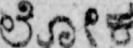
ಲೋಕ
